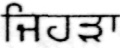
ਜਿਹੜਾ
